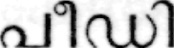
പീഡി
